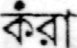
করা
